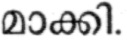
മാക്കി.
